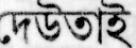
দেউতাই
